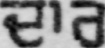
ਦਾਰ
